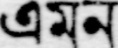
এমন
